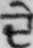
ਦੇ
